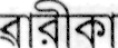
ৱারীকা
